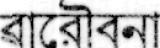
ৱারৌবনা
